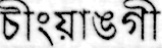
চীংয়াঙগী
